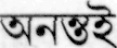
অনন্তই
